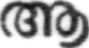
ആ
